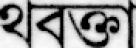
থবক্তা
